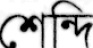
শেন্দি
